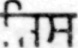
ਜਿਸ
